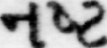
નષ્ટ
